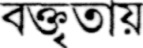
বক্তৃতায়
